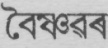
বৈষ্ণৱৰ
